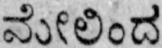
ಮೇಲಿಂದ
